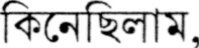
কিনেছিলাম,
